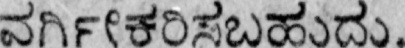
ವರ್ಗೀಕರಿಸಬಹುದು.
